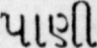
પાણી
